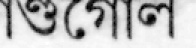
গণ্ডগোল
